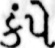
કંપે
